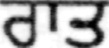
ਰਾਤ
